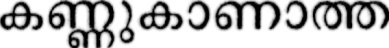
കണ്ണുകാണാത്ത
